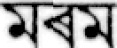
মৰম
